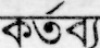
কর্তব্য
